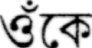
ওঁকে
